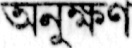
অনুক্ষণ
